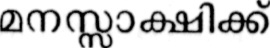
മനസ്സാക്ഷിക്ക്
